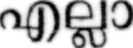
എല്ലാ
